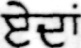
ਏਦਾਂ
